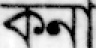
কনা
